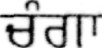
ਚੰਗਾ
